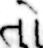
તો
